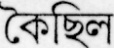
কৈছিল
